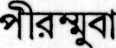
পীরম্মুবা
